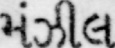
મંઝીલ
